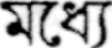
মধ্যে
